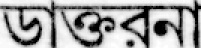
ডাক্তরনা
